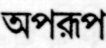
অপরূপ
